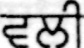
ਵਲੀ
